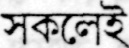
সকলেই
